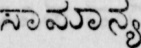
ಸಾಮಾನ್ಯ
